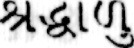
શ્રદ્ધાળુ
